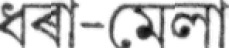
ধৰা-মেলা
